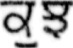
ਕੁਝ
